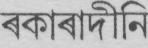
ৰকাৰাদীনি
